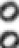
ঃ
